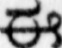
ಈ
